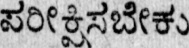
ಪರೀಕ್ಷಿಸಬೇಕು
